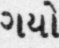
ગયો
